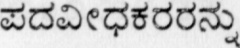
ಪದವೀಧಕರರನ್ನು
